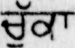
ਚੁੱਕਾ
